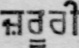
ਜ਼ਰੂਰੀ
